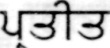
ਪ੍ਰਤੀਤ
